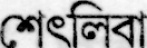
শেৎলিবা
